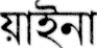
য়াইনা
